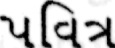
પવિત્ર
